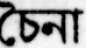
চৈনা
